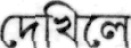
দেখিলে
